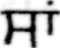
ਸਾਂ
